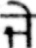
ਜੇ
